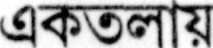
একতলায়
